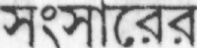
সংসারের
